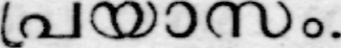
പ്രയാസം.
